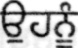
ਉਹਨੂੰ
